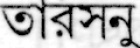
তারসনু
